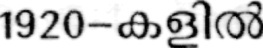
1920-കളില്‍
